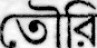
তৌরি
